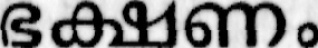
ഭക്ഷണം
